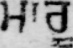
ਮਾਰੂ
